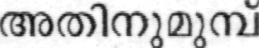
അതിനുമുമ്പ്
